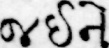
જઈને
